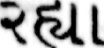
રહ્યા
